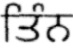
ਤਿੰਨ
